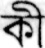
কী
